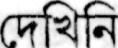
দেখিনি
